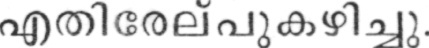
എതിരേല്പുകഴിച്ചു.
